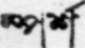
স্পর্শ
